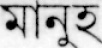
মানুহ
